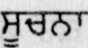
ਸੂਚਨਾ
